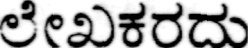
ಲೇಖಕರದು
